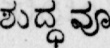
ಶುದ್ಧವೂ
